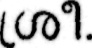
ശ്രീ.
